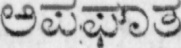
ಅಪಘಾತ
